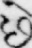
છે
